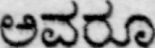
ಅವರೂ
